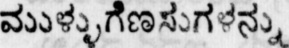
ಮುಳ್ಳುಗೆಣಸುಗಳನ್ನು
